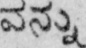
ವನ್ನು
